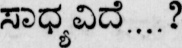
ಸಾಧ್ಯವಿದೆ....?
